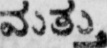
ಮತ್ತು
